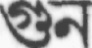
গুন
